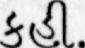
કહી.
